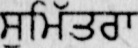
ਸੁਮਿੱਤਰਾ
